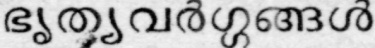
ഭൃത്യവര്‍ഗ്ഗങ്ങള്‍
